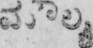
ಮೌಲ್ಯ
